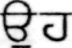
ਉਹ
